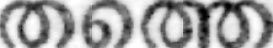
തത്തെ
